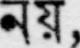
নয়,
